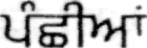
ਪੰਛੀਆਂ
